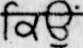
ਕਿਉਂ
